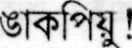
ঙাকপিয়ু!
